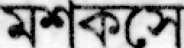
মশকসে
